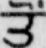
ਤੋਂ
